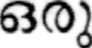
ഒരു
